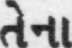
તેના
